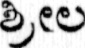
ಶ್ರೀಲ
